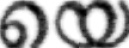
യെ
